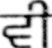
ਵੀ
